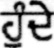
ਹੁੰਦੇ
